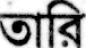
তারি
